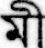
মী
